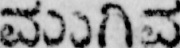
ಮುಗಿವ
